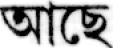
আছে
